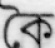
কৈ
